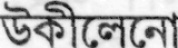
উকীলেনো
